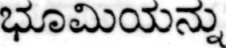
ಭೂಮಿಯನ್ನು
